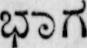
ಭಾಗ
